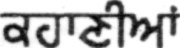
ਕਹਾਣੀਆਂ
